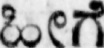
ಹೀಗೆ
